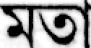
মতা
